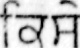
ਕਿਸੇ
